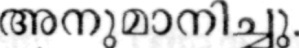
അനുമാനിച്ചു.
